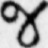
જ
